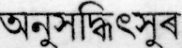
অনুসদ্ধিৎসুৰ
